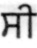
ਸੀ
